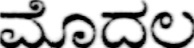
ಮೊದಲ
